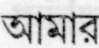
আমার
